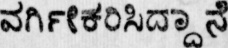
ವರ್ಗೀಕರಿಸಿದ್ದಾನೆ
